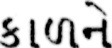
કાળને
